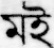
মই
